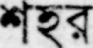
শহর
